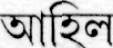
আহিল
